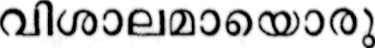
വിശാലമായൊരു
